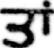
ਤਾਂ
